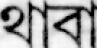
থাবা
